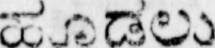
ಹೂಡಲು
